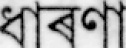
ধাৰণা
